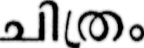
ചിത്രം
